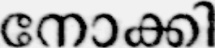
നോക്കി
